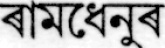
ৰামধেনুৰ
